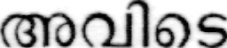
അവിടെ
